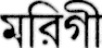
মরিগী
